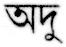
অদু
